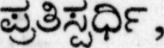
ಪ್ರತಿಸ್ಪರ್ಧಿ,
